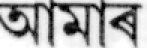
আমাৰ
